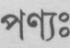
পণ্যঃ
